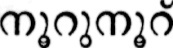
നൂറുനൂറ്
